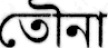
তৌনা
